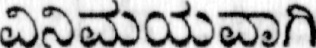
ವಿನಿಮಯವಾಗಿ
